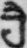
ਹੈ
